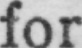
for
